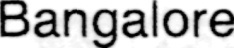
Bangalore
